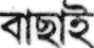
বাছাই
